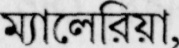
ম্যালেরিয়া,
